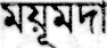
ময়ূমদা
